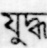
যুদ্ধ
